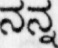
ನನ್ನ
